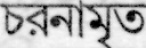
চরনামৃত
